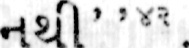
નથી"૪૨
